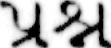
પ્રશ્ન
